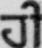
ਹੀ
